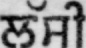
ਲੱਸੀ
